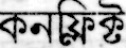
কনফ্লিক্ট
